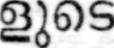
ളുടെ
